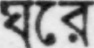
ঘরে
